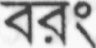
বরং
